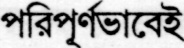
পরিপূর্ণভাবেই
